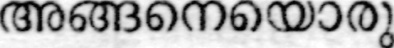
അങ്ങനെയൊരു
